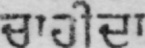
ਚਾਹੀਦਾ
